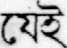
যেই
